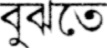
বুঝতে
